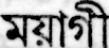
ময়াগী
